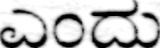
ಎಂದು
